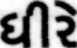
ધીરે
